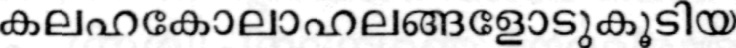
കലഹകോലാഹലങ്ങളോടുകൂടിയ
